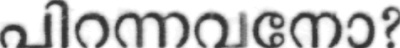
പിറന്നവനോ?
